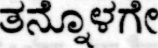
ತನ್ನೊಳಗೇ
